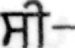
ਸੀ-
